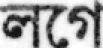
লগে
